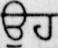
ਉਹ
